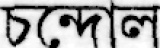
চন্দোল
